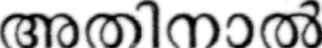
അതിനാല്‍
